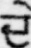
ਦੇ
